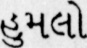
હુમલો
